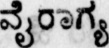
ವೈರಾಗ್ಯ
